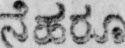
ನೆಹರೂ
